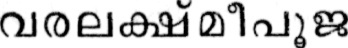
വരലക്ഷ്മീപൂജ
